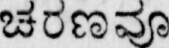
ಚರಣವೂ
